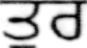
ਤੁਰ
